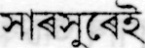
সাৰসুৰেই
